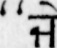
''ਜੇ
